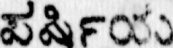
ಪರ್ಷಿಯ
